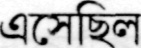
এসেছিল
